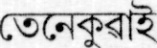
তেনেকুৱাই
